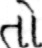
તો
